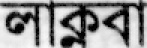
লাক্নবা
